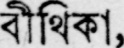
বীথিকা,
